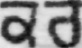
ਕਰ
